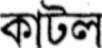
কাটল
